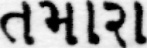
તમારા
